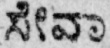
ಸೇವಾ
